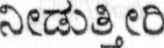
ನೀಡುತ್ತೀರಿ
